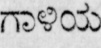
ಗಾಳಿಯ
